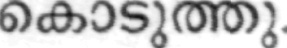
കൊടുത്തു.
